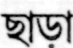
ছাড়া
